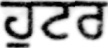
ਹੁਟਰ
